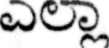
ಎಲ್ಲಾ
